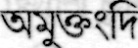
অমুক্তংদি
